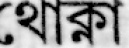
থোক্না
